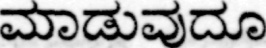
ಮಾಡುವುದೂ
